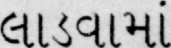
લાડવામાં
